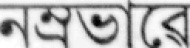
নম্রভাৱে
